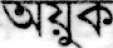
অয়ুক
